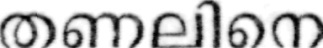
തണലിനെ
